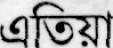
এতিয়া
